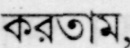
করতাম,
